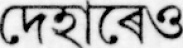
দেহাৰেও
